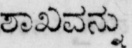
ಶಾಖವನ್ನು
